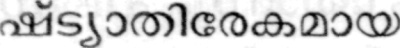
ഷ്ട്യാതിരേകമായ
